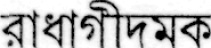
রাধাগীদমক
